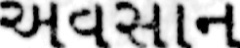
અવસાન
